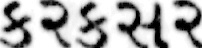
કરકસર
